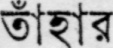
তাঁহার
